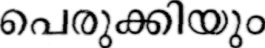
പെരുക്കിയും
